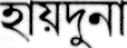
হায়দুনা
